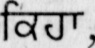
ਕਿਹਾ,
